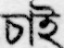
চাই
